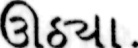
ઊઠ્યા.
